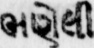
ભણેલી
